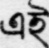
এই
